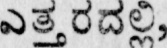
ಎತ್ತರದಲ್ಲಿ,
